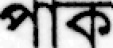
পাক
